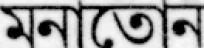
মনাতোন
